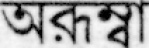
অরূম্বা
